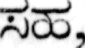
ಸಹ,
